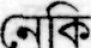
নেকি
